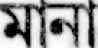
মানা
